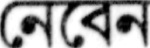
নেবেন
